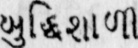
બુદ્ધિશાળી
